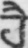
ਹੈ
